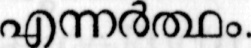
എന്നര്‍ത്ഥം.
